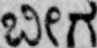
ಬೀಗ
